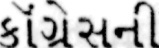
કૉંગ્રેસની
